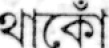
থাকোঁ
